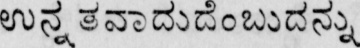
ಉನ್ನತವಾದುದೆಂಬುದನ್ನು
